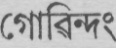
গোৱিন্দং
